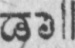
ಡಾ||
